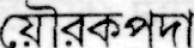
য়ৌরকপদা
